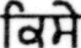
ਕਿਸੇ
